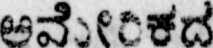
ಅಮೇರಿಕದ
